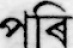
পৰি
